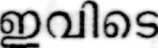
ഇവിടെ
